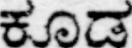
ಕೂಡ
